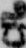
ಕೆ
